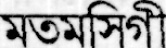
মতমসিগী
